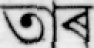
তাৰ
